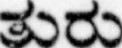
ತುರು
